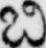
ಬಿ
